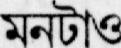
মনটাও
